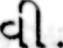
વી.
